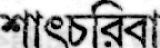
শাৎচরিবা
